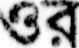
ওর
